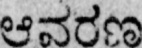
ಅವರಣ
